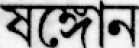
ষঙ্গোন
